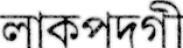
লাকপদগী
